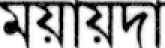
ময়ায়দা
